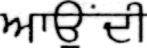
ਆਉਂਦੀ
